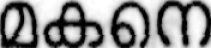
മകനെ
